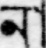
না
